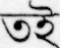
তই
